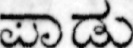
ಪಾಡು
